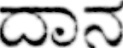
ದಾನ
